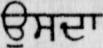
ਉਸਦਾ
